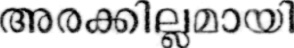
അരക്കില്ലമായി
